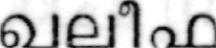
ഖലീഫ
